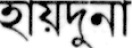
হায়দুনা
